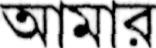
আমার
